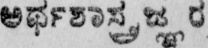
ಅರ್ಥಶಾಸ್ತ್ರಜ್ಞರ
